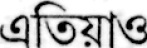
এতিয়াও
